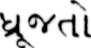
ધ્રૂજતો
